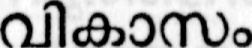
വികാസം
